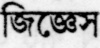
জিজ্ঞেস
